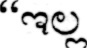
"ಇಲ್ಲ
